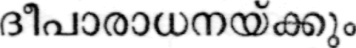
ദീപാരാധനയ്ക്കും
